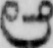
ಆ
